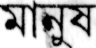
মানুষ
